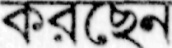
করছেন
